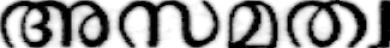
അസമത്വ
